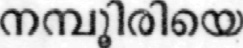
നമ്പൂിരിയെ
